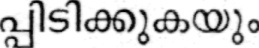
പ്പിടിക്കുകയും
